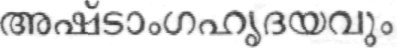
അഷ്ടാംഗഹൃദയവും
